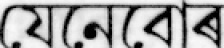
যেনেবোৰ
